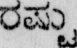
ರಷ್ಟು
